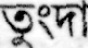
তুংদা
